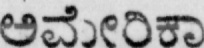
ಅಮೇರಿಕಾ
